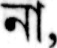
না,
